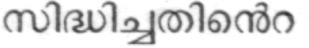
സിദ്ധിച്ചതിന്റെ
